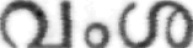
വംശ
